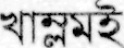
খাম্লকই
